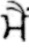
ਮੈਂ
